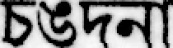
চঙদনা
